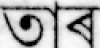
তাৰ
